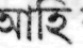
আহি
